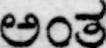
ಅಂತ
